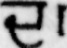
ਦਾ
